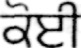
ਕੋਈ
